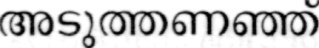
അടുത്തണഞ്ഞ്
